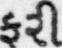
ફરી
